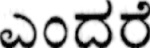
ಎಂದರೆ
